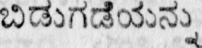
ಬಿಡುಗಡೆಯನ್ನು
